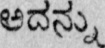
ಅದನ್ನು
